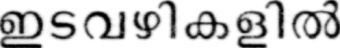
ഇടവഴികളില്‍
